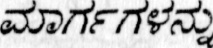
ಮಾರ್ಗಗಳನ್ನು
